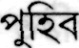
পুহিব
